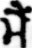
ਮੈਂ
